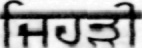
ਜਿਹੜੀ
